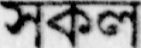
সকল
